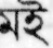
মই
